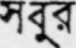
সবুর
